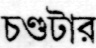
চণ্ডটার
